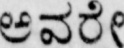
ಅವರೇ
